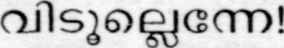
വിടൂല്ലെന്നേ!
